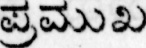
ಪ್ರಮುಖ
